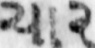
ચાર
